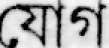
যোগ
